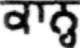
ਕਾਨ੍ਹ
